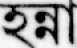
হন্না
